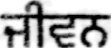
ਜੀਵਨ
